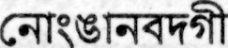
নোংঙানবদগী
